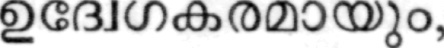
ഉദ്വേഗകരമായും,
